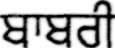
ਬਾਬਰੀ
